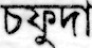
চফুদা
